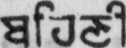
ਬਹਿਣੀ
